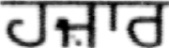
ਹਜ਼ਾਰ
